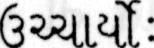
ઉચ્ચાર્યોઃ
